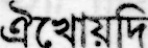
ঐখোয়দি
